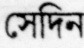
সেদিন
